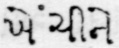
ખેંચીને
